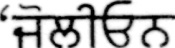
'ਜੋਲੀਓਨ
